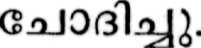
ചോദിച്ചു.
